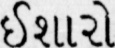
ઈશારો
